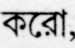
করো,
